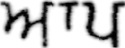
ਆਪ
